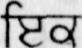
ਇਕ
